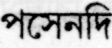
পসেনদি
